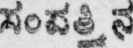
ಸಂಪತ್ತಿನ
